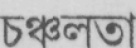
চঞ্চলতা
